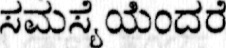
ಸಮಸ್ಯೆಯೆಂದರೆ
